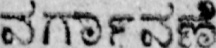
ವರ್ಗಾವಣಿ
